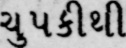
ચુપકીથી
